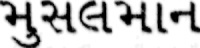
મુસલમાન
